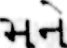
મને
